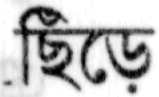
ছিঁড়ে
